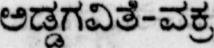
ಅಡ್ಡಗವಿತೆ-ವಕ್ರ
